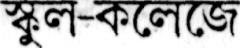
স্কুল-কলেজে
